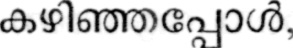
കഴിഞ്ഞപ്പോള്‍,
